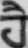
ਹੈ
